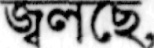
জ্বলছে,
